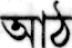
আঠ
